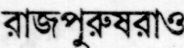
রাজপুরুষরাও
